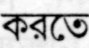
করতে
